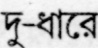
দু-ধারে
